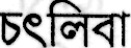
চৎলিবা
